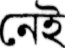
নেই
